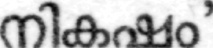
നികഷം'
